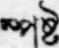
স্পষ্ট
